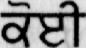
ਕੋਈ
